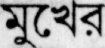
মুখের
